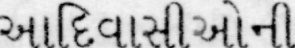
આદિવાસીઓની
